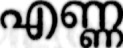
എണ്ണ
